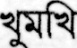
খুমখি
